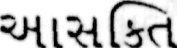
આસક્તિ
